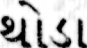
થોડા
